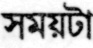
সময়টা
